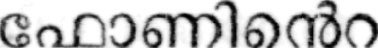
ഫോണിന്റെ
